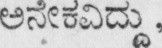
ಅನೇಕವಿದ್ದು,
